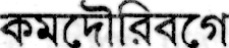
কমদৌরিবগে
